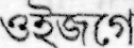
ওইজগে
